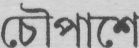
চৌপাশে
